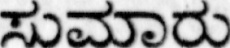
ಸುಮಾರು
